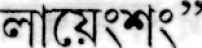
লায়েংশং”
